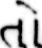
તો
